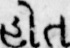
હોત
